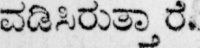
ವಡಿಸಿರುತ್ತಾರೆ.
